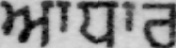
ਆਧਾਰ
